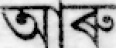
আৰু
